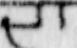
ਦਾ
